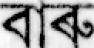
বাৰু
